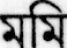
মমি
